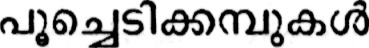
പൂച്ചെടിക്കമ്പുകള്‍
